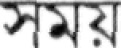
সময়
